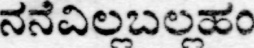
ನನೆವಿಲ್ಲಬಲ್ಲಹಂ
